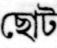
ছোট
